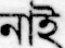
নাই
